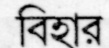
বিহার
